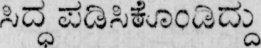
ಸಿದ್ಧಪಡಿಸಿಕೊಂಡಿದ್ದು
